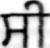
ਸੀ
